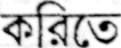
করিতে
